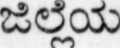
ಜಿಲ್ಲೆಯ
